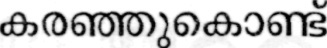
കരഞ്ഞുകൊണ്ട്
